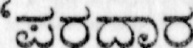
‘ಪರದಾರ
